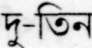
দু-তিন
